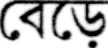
বেড়ে
